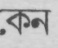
কেন
